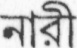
নারী
